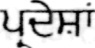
ਪ੍ਰਦੇਸ਼ਾਂ
